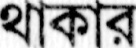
থাকার
